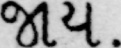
જાય.
